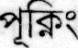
পূক্নিং
